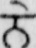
ਨੇ
